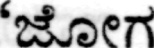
‘ಜೋಗ
